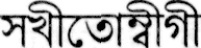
সখীতোম্বীগী
